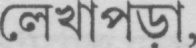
লেখাপড়া,
